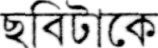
ছবিটাকে
